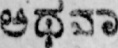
ಅಥವಾ
